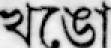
খঙো
